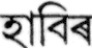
হাবিৰ
